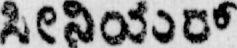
ಸೀನಿಯರ್
